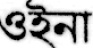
ওইনা
